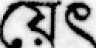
য়েৎ
